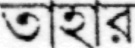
তাহার
